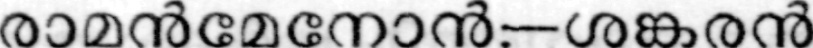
രാമന്‍മേനോന്‍:-ശങ്കരന്‍
